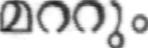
മററും
